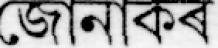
জোনাকৰ
